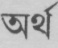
অৰ্থ
